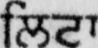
ਲਿਟਾ
